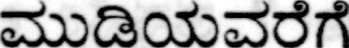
ಮುಡಿಯವರೆಗೆ
